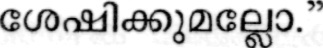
ശേഷിക്കുമല്ലോ.”
